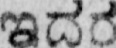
ಇದರ
